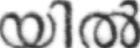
യില്‍
